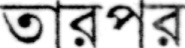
তারপর
